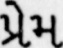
પ્રેમ
